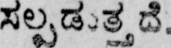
ಸಲ್ಪಡುತ್ತದೆ.
